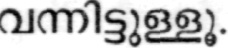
വന്നിട്ടുള്ളൂ.
